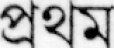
প্রথম
